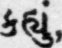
કહ્યું,
